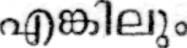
എങ്കിലും
